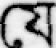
যে
